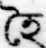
হৈ
